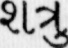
શત્રુ
